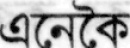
এনেকৈ
